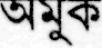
অমুক
